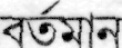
বর্তমান
